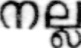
നല്ല
